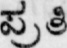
ಪ್ರತಿ
